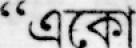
"একো
